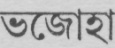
ভজোহা
